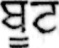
ਬੂਟ
